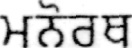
ਮਨੋਰਥ
